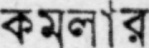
কমলার
